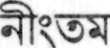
নীংতম
